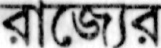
রাজ্যের
